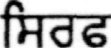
ਸਿਰਫ
